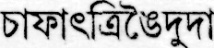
চাফাৎত্রিঙৈদুদা
